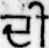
ਦੀ
